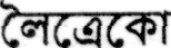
লৈত্রেকো
